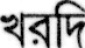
খরদি
